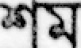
শম
